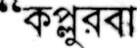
“কপ্লুরবা
